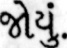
જોયું.
